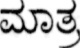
ಮಾತ್ರ
